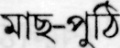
মাছ-পুঠি
